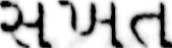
સખત
